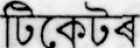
টিকেটৰ
